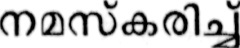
നമസ്കരിച്ച്
